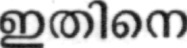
ഇതിനെ
